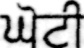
ਘੋਟੀ
